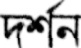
দর্শন
